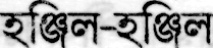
হঞ্জিল-হঞ্জিল
